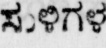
ಸುಳಿಗಳ
